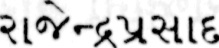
રાજેન્દ્રપ્રસાદ
